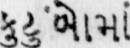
કુટુંબોમાં
